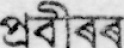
প্রবীৰৰ
